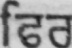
ਫਿਰ
